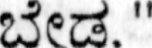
ಬೇಡ.”
